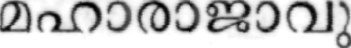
മഹാരാജാവു
